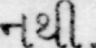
નથી.
